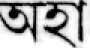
অহা
